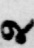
જ
